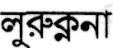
লুরুক্ননা
